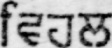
ਵਿਹਲ
